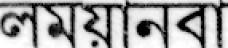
লময়ানবা
